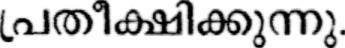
പ്രതീക്ഷിക്കുന്നു.
